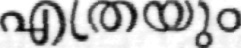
എത്രയും
